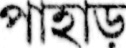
পাহাড়
